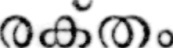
രക്തം
